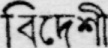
বিদেশী
